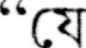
“যে
